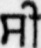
ਸੀ
